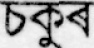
চকুৰ
